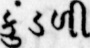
કુંડળી
